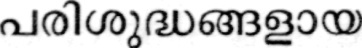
പരിശുദ്ധങ്ങളായ
